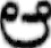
ಆ
